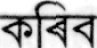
কৰিব
